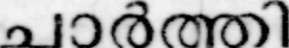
ചാര്‍ത്തി
